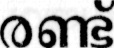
രണ്ട്
